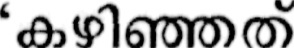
‘കഴിഞ്ഞത്
